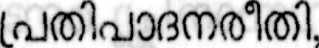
പ്രതിപാദനരീതി,
